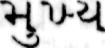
મુખ્ય
